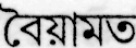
বৈয়ামত
